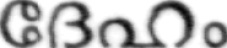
ദേഹം
